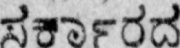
ಸರ್ಕಾರದ
